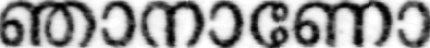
ഞാനാണോ
